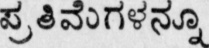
ಪ್ರತಿಮೆಗಳನ್ನೂ
